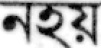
নহয়
